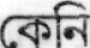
কেনি
